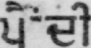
ਪੈਂਦੀ
